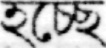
হচ্ছে
